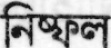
নিষ্ফল
